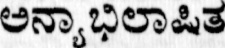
ಅನ್ಯಾಭಿಲಾಷಿತ
